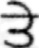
ਤੇ
